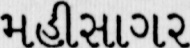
મહીસાગર
